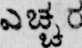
ಎಚ್ಚರ
